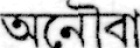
অনৌবা
